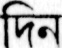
দিন
